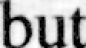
but
